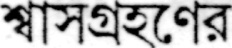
শ্বাসগ্রহণের
